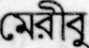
মেরীবু
